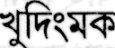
খুদিংমক
